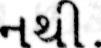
નથી.
